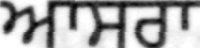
ਆਸਰਾ
